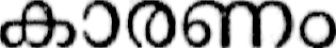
കാരണം
